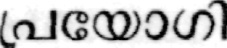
പ്രയോഗി
